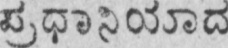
ಪ್ರಧಾನಿಯಾದ
